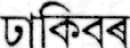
ঢাকিবৰ
